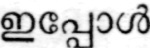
ഇപ്പോള്‍
